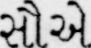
સૌએ
